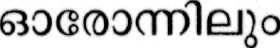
ഓരോന്നിലും
